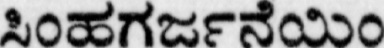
ಸಿಂಹಗರ್ಜನೆಯಿಂ
